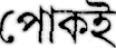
পোকই
